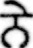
ਨੇ
